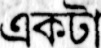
একটা
